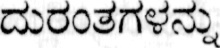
ದುರಂತಗಳನ್ನು
